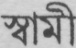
স্বামী
